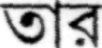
তার
